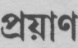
প্ৰয়াণ
